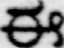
ಈ
